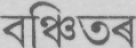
বঞ্চিতৰ
